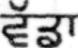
ਵੱਡਾ
